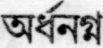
অর্ধনগ্ন
